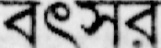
বৎসর
